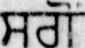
ਸਗੋਂ
